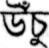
উঁচু
